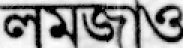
লমজাও
